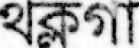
থক্লগা
